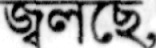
জ্বলছে,
